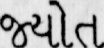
જ્યોત
